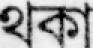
থকা
